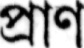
প্রাণ
